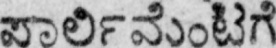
ಪಾರ್ಲಿಮೆಂಟಿಗೆ
